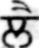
ਲੈ
